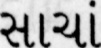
સાચાં
